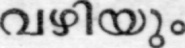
വഴിയും
